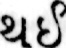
થઈ
